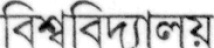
বিশ্ববিদ্যালয়
